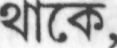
থাকে,
